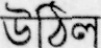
উঠিল
